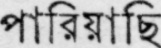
পারিয়াছি
